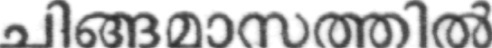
ചിങ്ങമാസത്തില്‍
